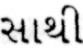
સાથી
